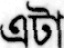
এটা
